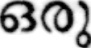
ഒരു
